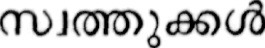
സ്വത്തുക്കള്‍
